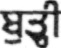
ਬੁੜ੍ਹੀ
